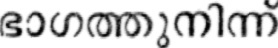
ഭാഗത്തുനിന്ന്
